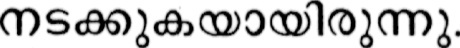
നടക്കുകയായിരുന്നു.
